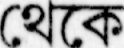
থেকে
